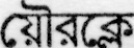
য়ৌরক্লে
